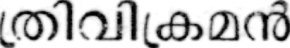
ത്രിവിക്രമന്‍
